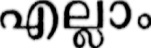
എല്ലാം
